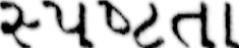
સ્પષ્ટતા
